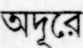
অদূরে
